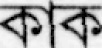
কাক
